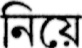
নিয়ে
